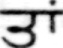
ਤਾਂ
